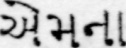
એમના
